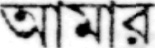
আমার
